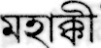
মহাক্কী
